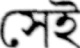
সেই
